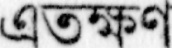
এতক্ষণ
